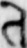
તે
